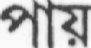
পায়
